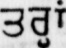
ਤਰ੍ਹਾਂ
